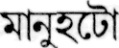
মানুহটো
